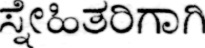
ಸ್ನೇಹಿತರಿಗಾಗಿ
